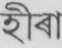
হীৰা
